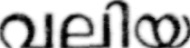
വലിയ
